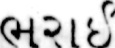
ભરાઈ
